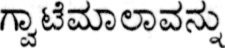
ಗ್ವಾಟೆಮಾಲಾವನ್ನು
